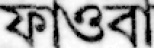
ফাওবা
